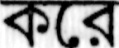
করে
